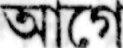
আগে
